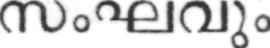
സംഘവും
